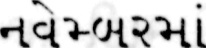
નવેમ્બરમાં
